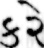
કરે
